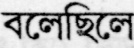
বলেছিলে
